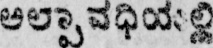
ಅಲ್ಪಾವಧಿಯಲ್ಲಿ
